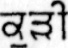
ਕੁੜੀ
